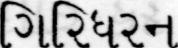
ગિરિધરન
